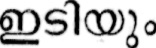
ഇടിയും
